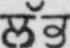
ਲੱਭ
